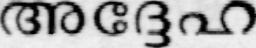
അദ്ദേഹ
